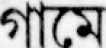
গামে
